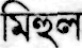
মিহুল
